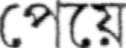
পেয়ে
